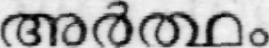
അര്‍ത്ഥം
